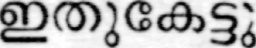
ഇതുകേട്ടു
